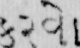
કરવો
